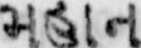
મહાન
